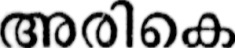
അരികെ
